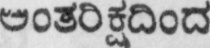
ಅಂತರಿಕ್ಷದಿಂದ
